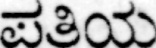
ಪತಿಯ
